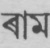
ৰাম
